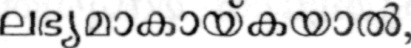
ലഭ്യമാകായ്കയാല്‍,
